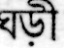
ঘড়ী
